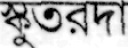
স্কূতরদা
